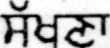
ਸੱਖਣਾ
